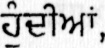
ਹੁੰਦੀਆਂ,
